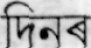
দিনৰ
